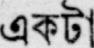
একটা
